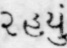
રહયું
